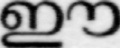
ഈ
